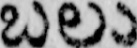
ಬಲು
